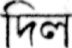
দিল
